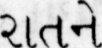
રાતને
